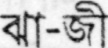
ঝা-জী
